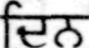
ਦਿਨ
